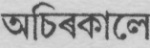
অচিৰকালে
